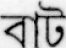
বাট
